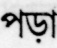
পড়া
